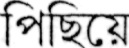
পিছিয়ে
